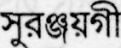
সুরঞ্জয়গী
